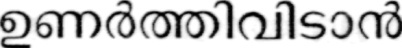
ഉണര്‍ത്തിവിടാന്‍
